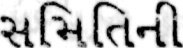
સમિતિની
